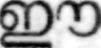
ഈ
